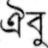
ঐবু
